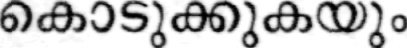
കൊടുക്കുകയും
